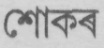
শোকৰ
